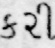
કરી
